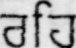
ਰਹਿ
